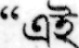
"এই
